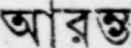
আরম্ভ
